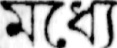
মধ্যে
